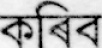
কৰিব
